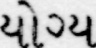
યોગ્ય
